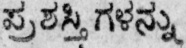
ಪ್ರಶಸ್ತಿಗಳನ್ನು
